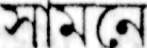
সামনে
